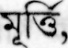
মূর্তি,
